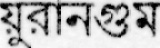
য়ুরানগুম
